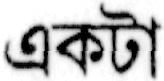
একটা
